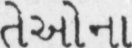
તેઓના
